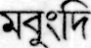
মবুংদি
